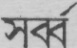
সৰ্ব্ব
